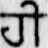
ਹੀ
